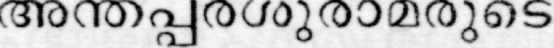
അന്തപ്പരശുരാമരുടെ
